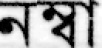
নম্বা
